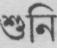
শুনি
